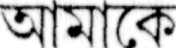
আমাকে
